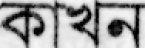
কাখন
